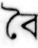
বৈ
